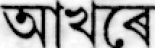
আখৰে
